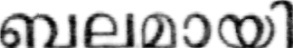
ബലമായി
